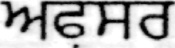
ਅਫ਼ਸਰ
